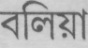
বলিয়া
